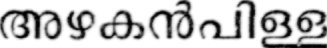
അഴകന്‍പിള്ള
